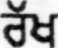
ਰੱਖ
